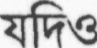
যদিও
